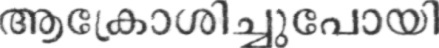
ആക്രോശിച്ചുപോയി
